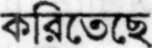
করিতেছে
